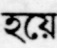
হয়ে
